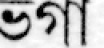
ভগা
